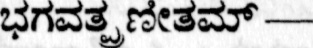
ಭಗವತ್ಪ್ರಣೀತಮ್-
